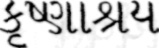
કૃષ્ણાશ્રય
